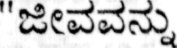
“ಜೀವವನ್ನು
